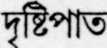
দৃষ্টিপাত
